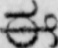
ಈ
